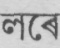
লৰে
